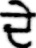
ਦੇ
